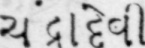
ચંદ્રાદેવી
